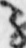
કે
